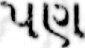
પણ
